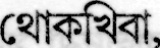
থোকখিবা,
